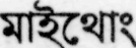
মাইথোং
